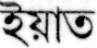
ইয়াত
